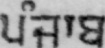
ਪੰਜਾਬ
